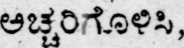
ಅಚ್ಚರಿಗೊಳಿಸಿ,
